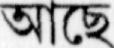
আছে
